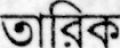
তারিক
